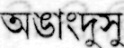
অঙাংদুসু
